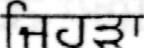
ਜਿਹੜਾ
